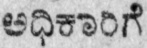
ಅಧಿಕಾರಿಗೆ
